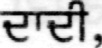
ਦਾਦੀ,
